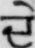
ਦੇ
